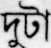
দুটা
